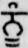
ਨੂੰ
